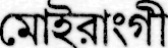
মোইরাংগী
